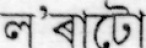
ল'ৰাটো
